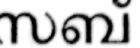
സബ്
